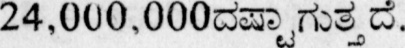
24,000,000ದಷ್ಟಾಗುತ್ತದೆ.
